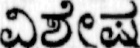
ವಿಶೇಷ
